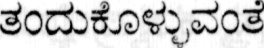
ತಂದುಕೊಳ್ಳುವಂತೆ
